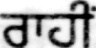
ਰਾਹੀਂ
